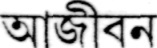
আজীবন
